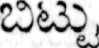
ಬಿಟ್ಟು
